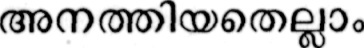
അനത്തിയതെല്ലാം
